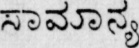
ಸಾಮಾನ್ಯ
